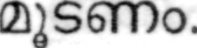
മൂടണം.
